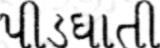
પીડઘાતી
